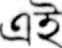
এই
